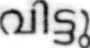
വിട്ടു
